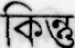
কিন্তু
